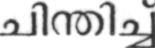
ചിന്തിച്ച്
